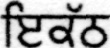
ਇਕੱਠ
